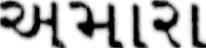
અમારા
